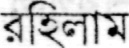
রহিলাম
